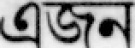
এজন
